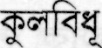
কুলবিধূ
